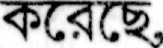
করেছে,
